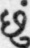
છું
